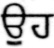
ਉਹ
